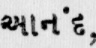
આનંદ,
